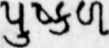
પુષ્કળ
